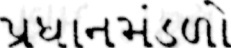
પ્રધાનમંડળો
